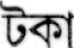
টকা
